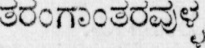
ತರಂಗಾಂತರವುಳ್ಳ
